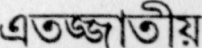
এতজ্জাতীয়
